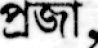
প্রজা,
